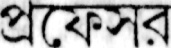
প্রফেসর
